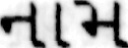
નામ
